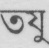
তযু
